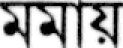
মমায়
